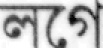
লগে
